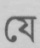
যে
